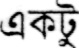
একটু
